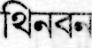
থিনবনা
